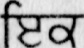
ਇਕ
